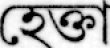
হেক্তা
